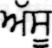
ਅੱਸੂ
